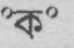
ক
